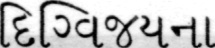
દિગ્વિજયના
